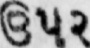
ઉપર
